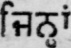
ਜਿਨ੍ਹਾਂ
